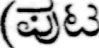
(ಪುಟ
